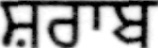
ਸ਼ਰਾਬ
